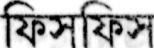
ফিসফিস
